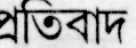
প্রতিবাদ
